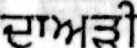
ਦਾਅੜੀ
